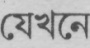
যেখনে
